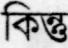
কিন্তু
